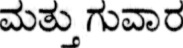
ಮತ್ತುಗುವಾರ
